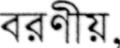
বরণীয়,
